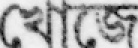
খোজে
